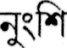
নুংশি
